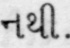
નથી.
